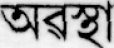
অৱস্থা
